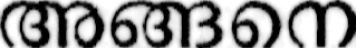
അങ്ങനെ
